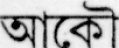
আকৌ
